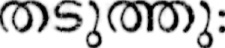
തടുത്തു:
